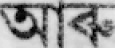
আৰু
